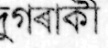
দুগৰাকী
